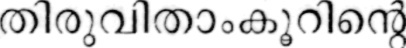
തിരുവിതാംകൂറിന്റെ
